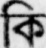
কি
